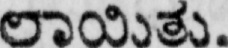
ಲಾಯಿತು.
